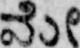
ಮೇ
